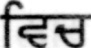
ਵਿਚ
